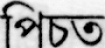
পিচত
